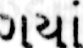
ગયાં
